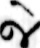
જે
